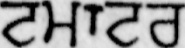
ਟਮਾਟਰ
